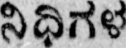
ನಿಧಿಗಳ
